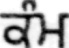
ਕੰਮ
